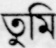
তুমি
